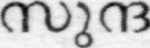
സുന്ദ
